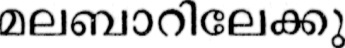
മലബാറിലേക്കു
